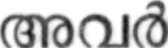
അവര്‍
